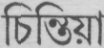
চিন্তিয়া
